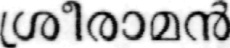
ശ്രീരാമന്‍
